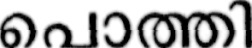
പൊത്തി
